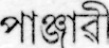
পাঞ্জাৱী
